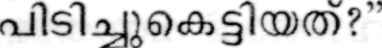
പിടിച്ചുകെട്ടിയത്?”
